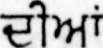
ਦੀਆਂ
